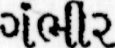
ગંભીર
